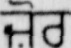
ਜ਼ੋਰ
